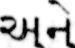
અને
